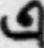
এ
